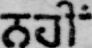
ਨਹੀਂ
